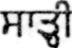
ਸਾੜ੍ਹੀ
